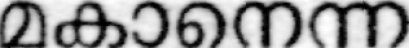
മകാനെന്ന
